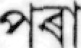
পৰা
